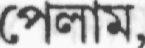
পেলাম,
